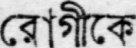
রোগীকে
